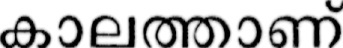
കാലത്താണ്
